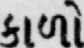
કાળો
